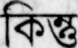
কিন্তু
